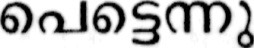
പെട്ടെന്നു
